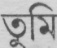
তুমি
